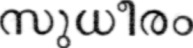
സുധീരം
